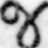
જ
